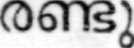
രണ്ടു
